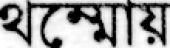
থম্মোয়
